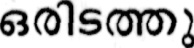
ഒരിടത്തു
